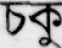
চকু
